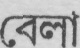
বেলা
